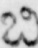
ಬಿ
